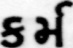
કર્મ
